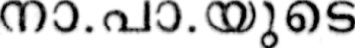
നാ.പാ.യുടെ
